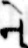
ને
